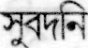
সুবদনি
